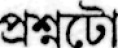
প্রশ্নটো
